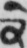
ਕੇ
